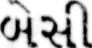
બેસી
